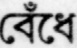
বেঁধে
